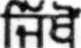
ਜਿੱਥੋਂ
